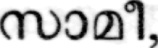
സാമീ,
